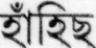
হাঁহিছ
